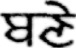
ਬਣੇ
